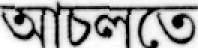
আচলতে
